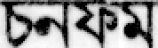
চনফম
